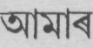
আমাৰ
